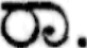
ರಾ.
